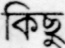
কিছু
